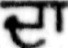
ਦਾ
